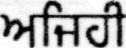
ਅਜਿਹੀ
